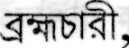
ব্রহ্মচারী,
